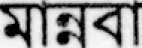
মান্নবা
